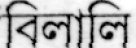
বিলালি
